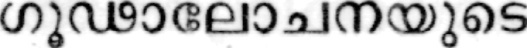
ഗൂഢാലോചനയുടെ
